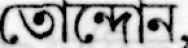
তোন্দোন,
